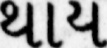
થાય
